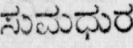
ಸುಮಧುರ
